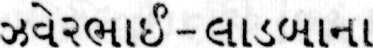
ઝવેરભાઈ-લાડબાના
